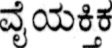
ವೈಯಕ್ತಿಕ
